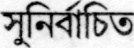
সুনির্বাচিত
